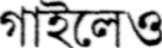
গাইলেও
